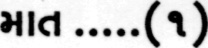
માત............(૧)
